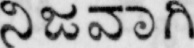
ನಿಜವಾಗಿ
